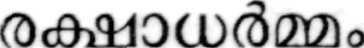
രക്ഷാധര്‍മ്മം
